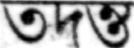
তদন্ত
